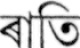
ৰাতি
